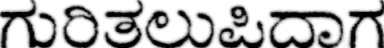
ಗುರಿತಲುಪಿದಾಗ
